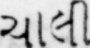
ચાલી
